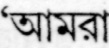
‘আমরা
